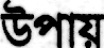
উপায়
